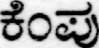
ಕೆಂಪು
